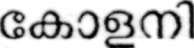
കോളനി
